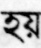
হয়
